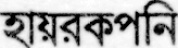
হায়রকপনি
